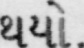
થયો.
